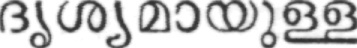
ദൃശ്യമായുള്ള
